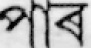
পাৰ
